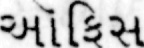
ઑફિસ
